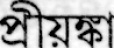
প্রীয়ঙ্কা
